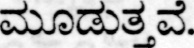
ಮೂಡುತ್ತವೆ.
